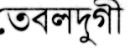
তেবলদুগী
